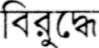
বিরুদ্ধে
